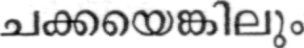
ചക്കയെങ്കിലും
